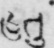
હતું
